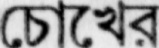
চোখের
